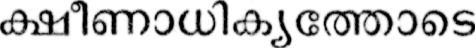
ക്ഷീണാധിക്യത്തോടെ
